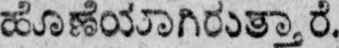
ಹೊಣೆಯಾಗಿರುತ್ತಾರೆ.
